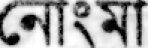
নোংমা
